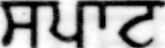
ਸਪਾਟ
